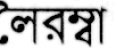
লৈরম্বা
